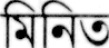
মিনিত
